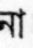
না
